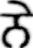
ਨੇ
